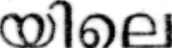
യിലെ
